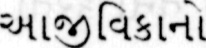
આજીવિકાનો
